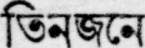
তিনজনে
